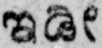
ಇಡೀ
